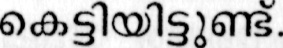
കെട്ടിയിട്ടുണ്ട്.
